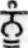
ਨੂੰ
